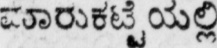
ಮಾರುಕಟ್ಟೆಯಲ್ಲಿ
